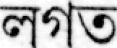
লগত
